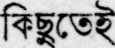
কিছুতেই
